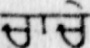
ਚਾਚੇ
